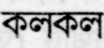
কলকল
